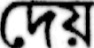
দেয়
